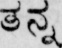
ತನ್ನ
